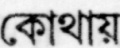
কোথায়
